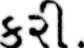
કરી.
